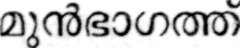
മുന്‍ഭാഗത്ത്
